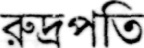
রুদ্রপতি
